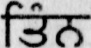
ਤਿੰਨ
